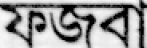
ফজবা
